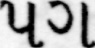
પગ
